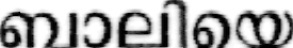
ബാലിയെ
